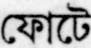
ফোটে
